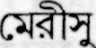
মেরীসু
